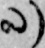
ಎ)
